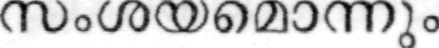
സംശയമൊന്നും
